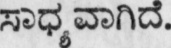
ಸಾಧ್ಯವಾಗಿದೆ.
